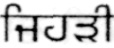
ਜਿਹੜੀ
